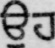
ਉਹ
